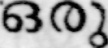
ഒരു
